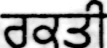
ਰਕਤੀ
